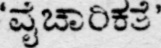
‘ವೈಚಾರಿಕತೆ’
